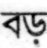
বড়
